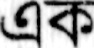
এক
